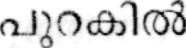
പുറകില്‍
